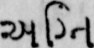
અગ્નિ
